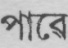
পাৱে
